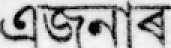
এজনাৰ
